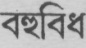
বহুবিধ
